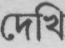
দেখি
